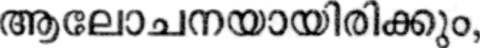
ആലോചനയായിരിക്കും,
